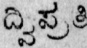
ದ್ವಿಪ್ರತಿ
